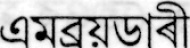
এমব্রয়ডাৰী
